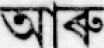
আৰু
